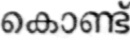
കൊണ്ട്
